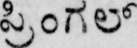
ಪ್ರಿಂಗಲ್
